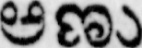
ಅಣು
